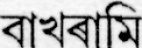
বাখৰামি
